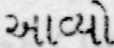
આવ્યો
